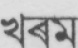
খৰম
